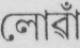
লোৱাঁ
